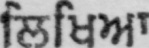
ਲਿਖਿਆ
